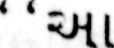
"આ
